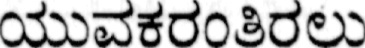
ಯುವಕರಂತಿರಲು
